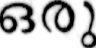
ഒരു
